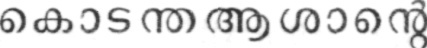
കൊടന്തആശാന്റെ
